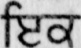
ਇਕ
